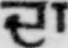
ਦਾ
